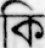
কি
